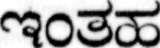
ಇಂತಹ
